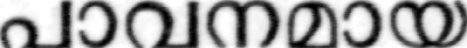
പാവനമായ
